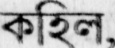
কহিল,
